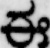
ಈ
